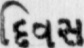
દિવસ
